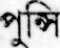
পুন্সি
